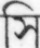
সি
